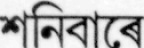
শনিবাৰে
